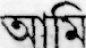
আমি
